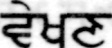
ਵੇਖਣ
